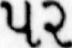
પર
